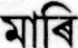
মাৰি
